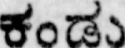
ಕಂಡು
